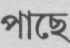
পাছে
